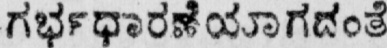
ಗರ್ಭಧಾರಣೆಯಾಗದಂತೆ
